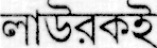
লাউরকই
